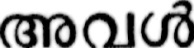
അവള്‍
